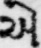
એ
